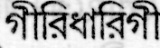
গীরিধারিগী
